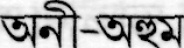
অনী-অহুম
